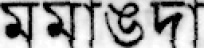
মমাঙদা
